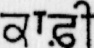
ਕਾਫ਼ੀ
